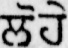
ਲੋਹੇ
